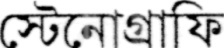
স্টেনোগ্রাফি
